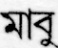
মাবু
